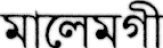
মালেমগী
